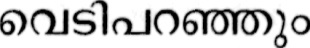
വെടിപറഞ്ഞും
